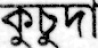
কুচুদা
